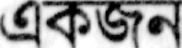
একজন
